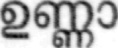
ഉണ്ണാ
